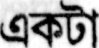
একটা
